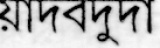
য়াদবদুদা
